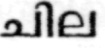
ചില
